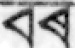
বৰ
